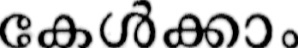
കേള്‍ക്കാം
